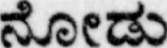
ನೋಡು
